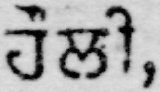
ਹੌਲੀ,
